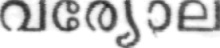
വര്യോല
